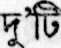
দু’টি
